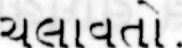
ચલાવતો.
